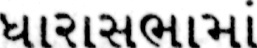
ધારાસભામાં
